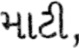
માટી,
